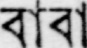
বাবা
